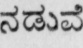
ನಡುವೆ
